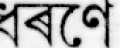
ধৰণে
